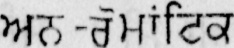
ਅਨ-ਰੋਮਾਂਟਿਕ
